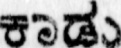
ಕಾಡು
